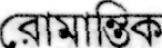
রোমান্তিক
